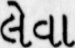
લેવા
